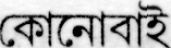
কোনোবাই
